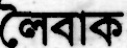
লৈবাক
